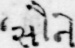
'સૌને
